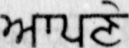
ਆਪਣੇ
